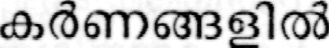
കര്‍ണങ്ങളില്‍
